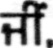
ਜੀਂ,
